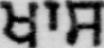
ਖਾਸ
